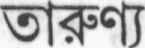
তারুণ্য
